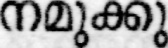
നമുക്കു
